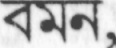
বমন,
